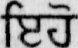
ਇਹੋ
